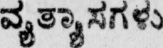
ವ್ಯತ್ಯಾಸಗಳು
